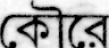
কৌরে
